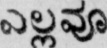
ಎಲ್ಲವೂ
